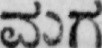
ಮಗ
